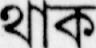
থাক
